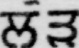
ਲੋੜ
